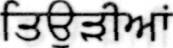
ਤਿਉੜੀਆਂ
